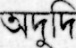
অদুদি
